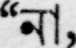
‘‘না,
